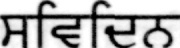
ਸਵਿਦਿਨ
